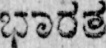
ಭಾರತ
